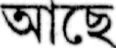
আছে
